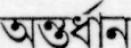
অন্তৰ্ধান
